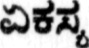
ಏಕಸ್ಯ
